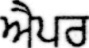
ਐਪਰ
